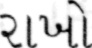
રાખો
